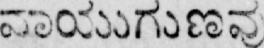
ವಾಯುಗುಣವು
